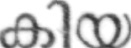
കിയ
